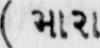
(મારા
